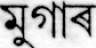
মুগাৰ
